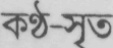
কণ্ঠ-সৃত
